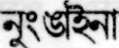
নুংঙাইনা
